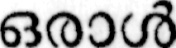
ഒരാള്‍
